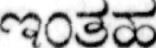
ಇಂತಹ
